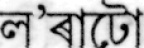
ল'ৰাটো
